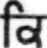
ਕਿ
